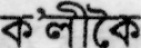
ক'লীকৈ
